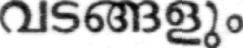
വടങ്ങളും
